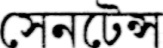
সেনটেন্স
